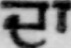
ਦਾ
